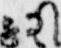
કરી
